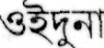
ওইদুনা
